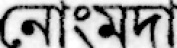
নোংমদা
